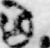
છે.
